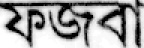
ফজবা
